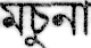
মচুনা
